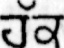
ਹੱਕ
